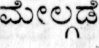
ಮೇಲ್ಗಡೆ
